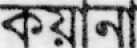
কয়ানা
